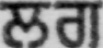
ਲਗ
